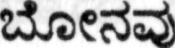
ಬೋನವು
